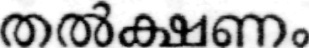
തല്‍ക്ഷണം
